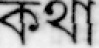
কথা
